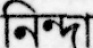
নিন্দা
